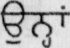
ਉਨ੍ਹਾਂ
